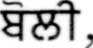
ਬੋਲੀ,
